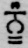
ਨੂੰ
